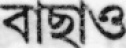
বাছাও
